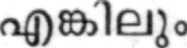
എങ്കിലും
